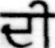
ਦੀ
